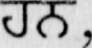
ਹਨ,
